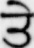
ਤੇ
